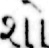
શો
